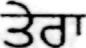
ਤੇਰਾ
